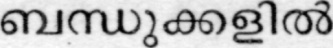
ബന്ധുക്കളില്‍
